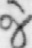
જે
